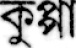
কুপ্পা
